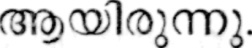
ആയിരുന്നു.
